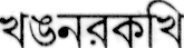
খঙনরকখি
